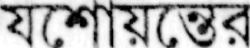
যশোয়ন্তের
